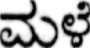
ಮಳೆ
